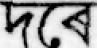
দৰে
